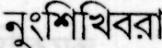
নুংশিখিবরা
